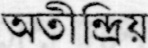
অতীন্দ্রিয়
